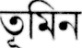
তূমিন
